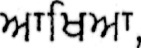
ਆਖਿਆ,
